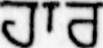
ਹਾਰ
